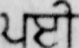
ਪਈ
